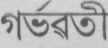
গৰ্ভৱতী
